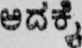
ಅದಕ್ಕೆ
